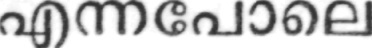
എന്നപോലെ
